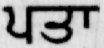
ਪਤਾ
